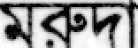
মরুদা
